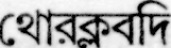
থোরক্লবদি
